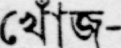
খোঁজ-
